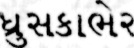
ધ્રુસકાભેર
